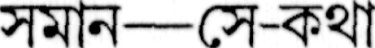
সমান-সে-কথা
